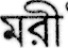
মরী
